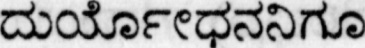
ದುರ್ಯೋಧನನಿಗೂ
